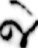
જે
